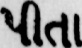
પીતા
